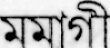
মমাগী
